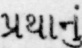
પ્રથાનું
